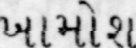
ખામોશ
